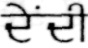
ਦੇਂਦੀ
